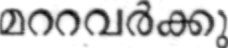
മററവര്‍ക്കു
